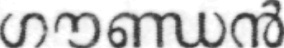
ഗൗണ്ഡന്‍
